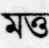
মত্ত
